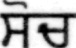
ਸੋਚ
